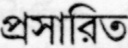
প্রসারিত
